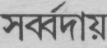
সৰ্ব্বদায়
